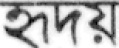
হৃদয়
